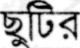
ছুটির
